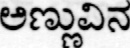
ಅಣ್ಣುವಿನ
